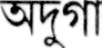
অদুগা
